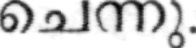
ചെന്നു.
